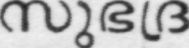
സുഭദ്ര
